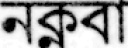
নক্নবা
